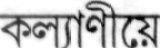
কল্যাণীয়ে
